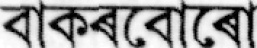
বাকৰবোৰো
